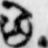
છે.
